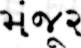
મંજૂર
